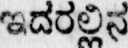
ಇದರಲ್ಲಿನ
